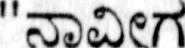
“ನಾವೀಗ
